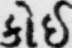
કોઈ
